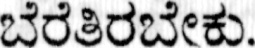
ಬೆರತಿರಬೇಕು.
